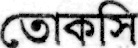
তোকসি
